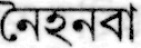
নৈহনবা
